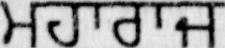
ਮਹਾਰਾਜ
